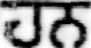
ਹਨ
